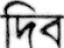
দিব
